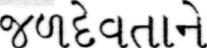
જળદેવતાને
